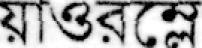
য়াওরম্লে
